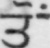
ਤੋਂ
